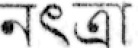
নৎত্রা
